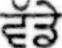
ਵੱਡੇ
